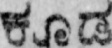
ಕೂಡ
